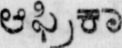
ಆಫ್ರಿಕಾ
